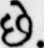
છે.
